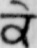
ਕੇ
